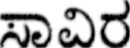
ಸಾವಿರ
